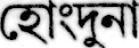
হোংদুনা
